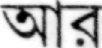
আর
